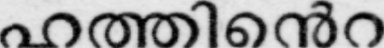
ഹത്തിന്റെ
